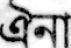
ঐনা
